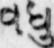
વધુ
